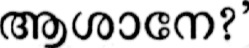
ആശാനേ?’
